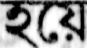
হয়ে
